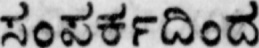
ಸಂಪರ್ಕದಿಂದ
